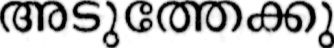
അടുത്തേക്കു
